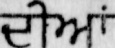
ਦੀਆਂ
